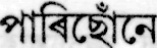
পাৰিছোঁনে
